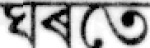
ঘৰতে
